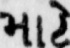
માટે
